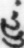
હું
